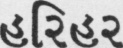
હરિહર
